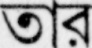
তার
